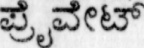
ಪ್ರೈವೇಟ್
